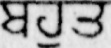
ਬਹੁਤ
